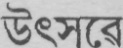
উৎসৱে
